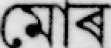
মোৰ
